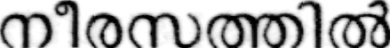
നീരസത്തില്‍
